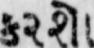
કરશો
